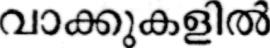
വാക്കുകളില്‍
